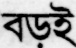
বড়ই
